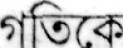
গতিকে
